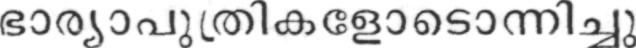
ഭാര്യാപുത്രികളോടൊന്നിച്ചു
